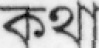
কথা
